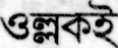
ওল্লকই
